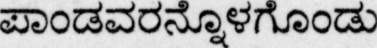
ಪಾಂಡವರನ್ನೊಳಗೊಂಡು
